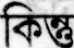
কিন্তু
